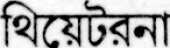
থিয়েটরনা
